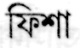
ফিশা
